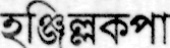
হঞ্জিল্লকপা
